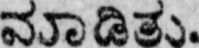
ಮಾಡಿತು.
